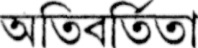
অতিবর্তিতা
